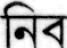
নিব
